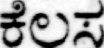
ಕೆಲಸ
